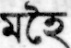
মহৈ
